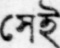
সেই
